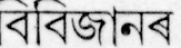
বিবিজানৰ
